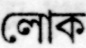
লোক
